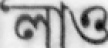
'লাও
